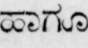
ಹಾಗೂ
